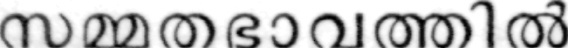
സമ്മതഭാവത്തില്‍
